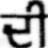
ਦੀ
